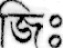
জিঃ
